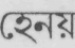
হেনয়
